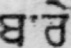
ਬਾਰੇ
